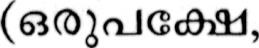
(ഒരുപക്ഷേ,
